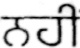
ਨਹੀਂ
